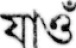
যাওঁ
